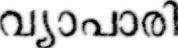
വ്യാപാരി
